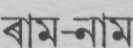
ৰাম-নাম
